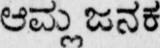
ಆಮ್ಲಜನಕ
